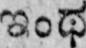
ಇಂಥ
